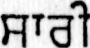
ਸਾਰੀ
